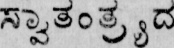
ಸ್ವಾತಂತ್ರ್ಯದ
